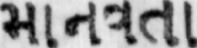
માનવતા
